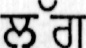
ਲੱਗ
